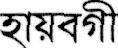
হায়বগী
